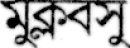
মুক্নবসু
